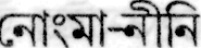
নোংমা-নীনি
